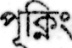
পূক্নিং
